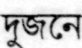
দুজনে
